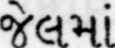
જેલમાં
